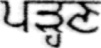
ਪੜ੍ਹਣ
